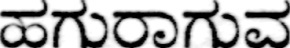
ಹಗುರಾಗುವ
